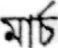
মার্চ
